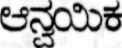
ಆನ್ವಯಿಕ
